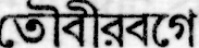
তৌবীরবগে
